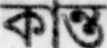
কান্ত
